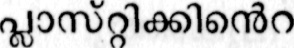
പ്ലാസ്‌റ്റിക്കിൻറെ
